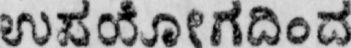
ಉಪಯೋಗದಿಂದ
